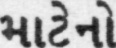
માટેનો
